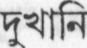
দুখানি
